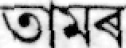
তামৰ
